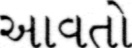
આવતો
